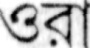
ওরা
